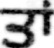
ਤਾਂ
